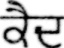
ਕੈਦ
